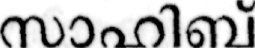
സാഹിബ്
